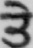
ਤੇ
